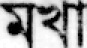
মখা
